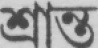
শ্ৰান্ত
